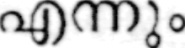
എന്നും
